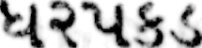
ધરપકડ
